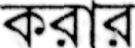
করার
